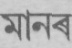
মানৰ
